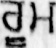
ਰੂਮ
